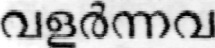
വളര്‍ന്നവ
